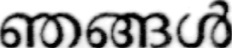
ഞങ്ങള്‍
